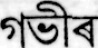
গভীৰ
